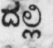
ದಲ್ಲಿ
